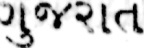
ગુજરાત
